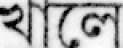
খালে
